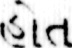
હોત
